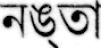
নঙ্তা
